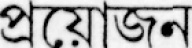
প্রয়োজন
